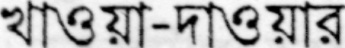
খাওয়া-দাওয়ার
